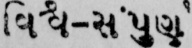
વિશ્વ-સંપુર્ણ
